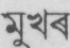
মুখৰ
